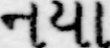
નયા
